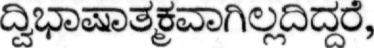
ದ್ವಿಭಾಷಾತ್ಮಕವಾಗಿಲ್ಲದಿದ್ದರೆ,
